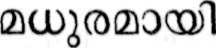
മധുരമായി
